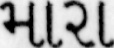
મારા
